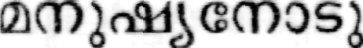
മനുഷ്യനോടു
